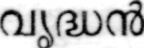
വൃദ്ധന്‍
